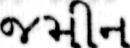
જમીન
